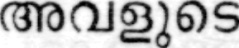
അവളുടെ
